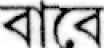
বাবে
